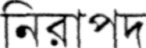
নিরাপদ
